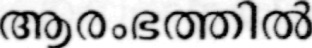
ആരംഭത്തില്‍
